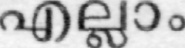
എല്ലാം
